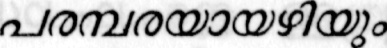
പരമ്പരയായഴിയും
